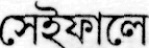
সেইফালে
